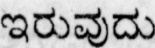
ಇರುವುದು
